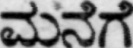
ಮನೆಗೆ
